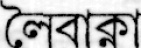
লৈবাক্না
